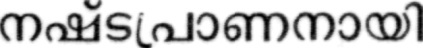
നഷ്ടപ്രാണനായി
